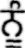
ਨੂੰ
